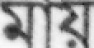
মায়
